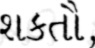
શકતૌ,
